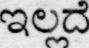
ಇಲ್ಲದೆ
